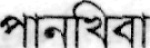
পানখিবা
